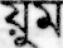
য়ুম
